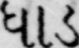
ધાડ
